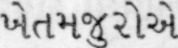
ખેતમજુરોએ
